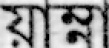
য়াম্না
